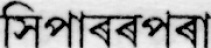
সিপাৰৰপৰা
